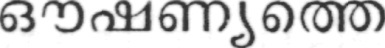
ഔഷണ്യത്തെ
